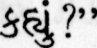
કહ્યું?"
